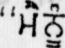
''ਮੈਨੂੰ
